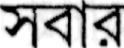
সবার
